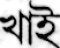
খাই
